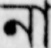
না
